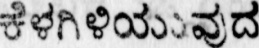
ಕೆಳಗಿಳಿಯುವುದ
